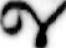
જ
